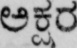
ಅಕ್ಷರ
